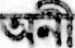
অনী
